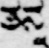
ತನ್ನ
